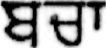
ਬਚਾ
